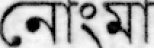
নোংমা
